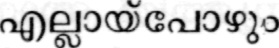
എല്ലായ്പോഴും
